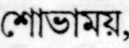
শোভাময়,
